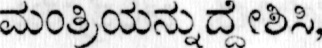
ಮಂತ್ರಿಯನ್ನುದ್ದೇಶಿಸಿ,
